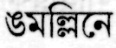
ঙমল্লিনে
